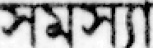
সমস্যা
